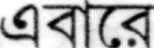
এবারে
